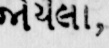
જોયેલા,
